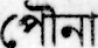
পৌনা
